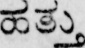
ಹತ್ತು
